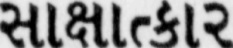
સાક્ષાત્કાર
